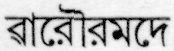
ৱারৌরমদে
